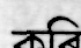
কৰি
